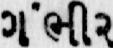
ગંભીર
